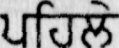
ਪਹਿਲੇ
